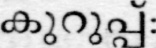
കുറുപ്പ്:
